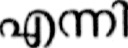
എന്നി
